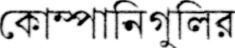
কোম্পানিগুলির
